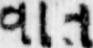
વાત
